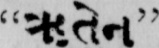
“ઋતેન”
